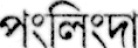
পংলিংদা
